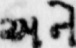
અને
